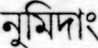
নুমিদাং
